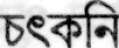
চৎকনি
